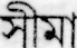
সীমা
